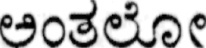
ಅಂತಲೋ
